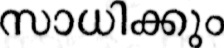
സാധിക്കും
